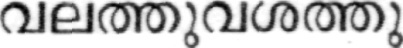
വലത്തുവശത്തു
